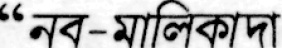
“নব-মালিকাদা
